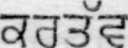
ਕਰਤੱਵ
